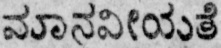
ಮಾನವೀಯತೆ
